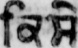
ਕਿਸੇ
